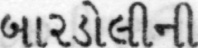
બારડોલીની
